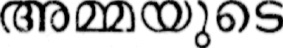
അമ്മയുടെ
